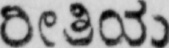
ರೀತಿಯ
